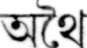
অথৈ
